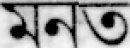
মনত
